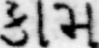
કામ
